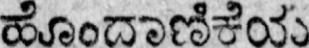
ಹೊಂದಾಣಿಕೆಯ
